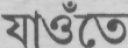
যাওঁতে
